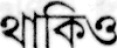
থাকিও
